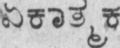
ಏಕಾತ್ಮಕ
